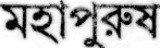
মহাপুরুষ
